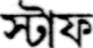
স্টাফ
